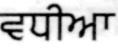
ਵਧੀਆ
